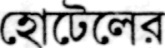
হোটেলের
